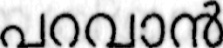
പറവാന്‍
